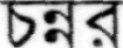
চন্নর
